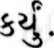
કર્યું.
